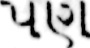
પણ
